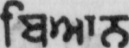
ਬਿਆਨ
